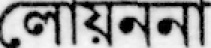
লোয়ননা
